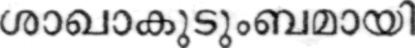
ശാഖാകുടുംബമായി
